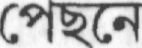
পেছনে
